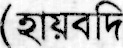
(হায়বদি
